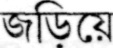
জড়িয়ে
